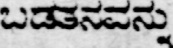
ಬಡತನವನ್ನು
